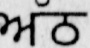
ਅੱਠ
